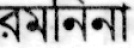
রমনিনা
